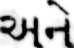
અને
